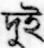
দুই
